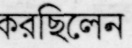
করছিলেন
